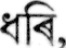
ধৰি,
